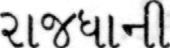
રાજધાની
